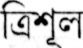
ত্রিশূল
